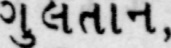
ગુલતાન,
